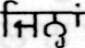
ਜਿਨ੍ਹਾਂ
